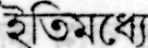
ইতিমধ্যে
